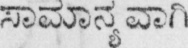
ಸಾಮಾನ್ಯವಾಗಿ
